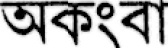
অকংবা
